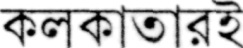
কলকাতারই
